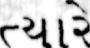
ત્યારે
